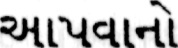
આપવાનો
